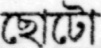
ছোটো
